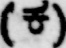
(ಕ)
